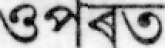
ওপৰত
